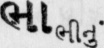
ભાભીનું
